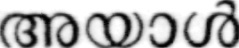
അയാള്‍
